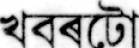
খবৰটো
